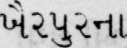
ખૈરપુરના
